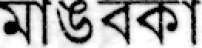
মাঙবকা
